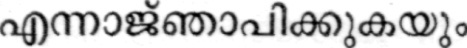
എന്നാജ്ഞാപിക്കുകയും
